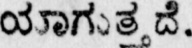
ಯಾಗುತ್ತದೆ.
